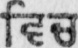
ਵਿਚ
